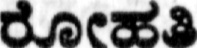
ರೋಹತಿ
